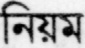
নিয়ম
